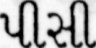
પીસી
